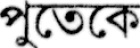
পুতেকে
